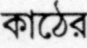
কাঠের
